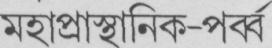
মহাপ্ৰাস্থানিক-পৰ্ব্ব
